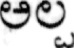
ಅಲ್ಪ
